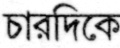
চারদিকে
